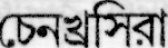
চেনখ্রসিরা
